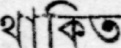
থাকিত
